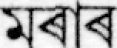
মৰাৰ
